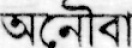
অনৌবা
